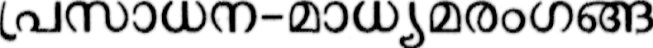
പ്രസാധന-മാധ്യമരംഗങ്ങ
